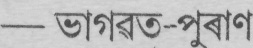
-ভাগৱত-পুৰাণ
